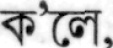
ক'লে,
